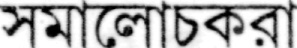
সমালোচকরা
